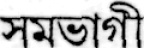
সমভাগী
